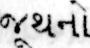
જૂથનો
